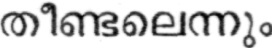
തീണ്ടലെന്നും
